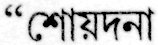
“শোয়দনা
